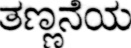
ತಣ್ಣನೆಯ
